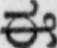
ಈ
